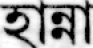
হান্না
